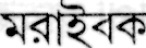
মরাইবক
